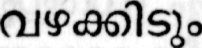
വഴക്കിടും
